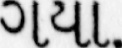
ગયા.
